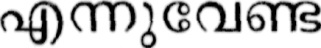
എന്നുവേണ്ട
